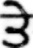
ਤੇ
